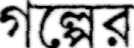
গল্পের
